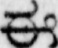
ಈ
